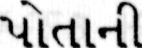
પોતાની
